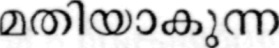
മതിയാകുന്ന
